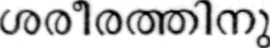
ശരീരത്തിനു
